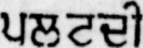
ਪਲਟਦੀ
